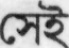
সেই
